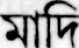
মাদি
